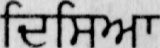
ਦਿਸਿਆ
